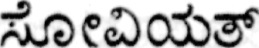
ಸೋವಿಯತ್
